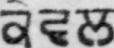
ਕੇਵਲ
